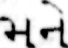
મને
